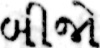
બીજો
